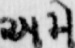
અમે
